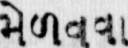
મેળવવા
